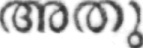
അതു
